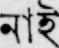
নাই
